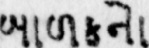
બાળકનો
